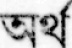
অর্থ
